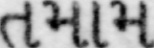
તમામ
